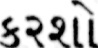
કરશો
